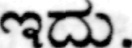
ಇದು.
